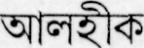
আলহীক
